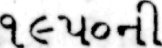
૧૯૫૦ની
